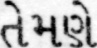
તેમણે
